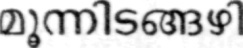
മൂന്നിടങ്ങഴി
